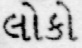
લોકો
